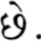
છે.
